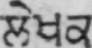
ਲੇਖਕ
